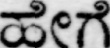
ಹೇಗೆ
